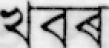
খবৰ
